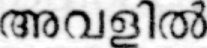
അവളില്‍
